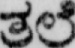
ತಲೆ
